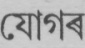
যোগৰ
